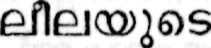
ലീലയുടെ
